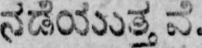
ನಡೆಯುತ್ತವೆ.
